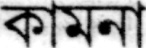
কামনা
